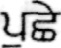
ਪੁਛੇ
